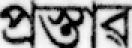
প্রস্তাৱ
